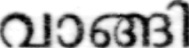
വാങ്ങി
